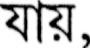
যায়,
